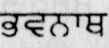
ਭਵਨਾਥ
